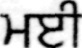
ਮਈ
